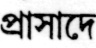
প্রাসাদে
